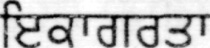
ਇਕਾਗਰਤਾ
